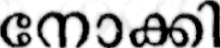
നോക്കി
